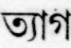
ত্যাগ
